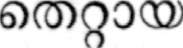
തെറ്റായ
